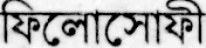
ফিলোসোফী
